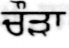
ਚੌੜਾ
